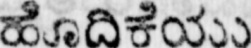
ಹೊದಿಕೆಯು
